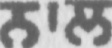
ਨਾਲ
